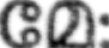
മേ:
